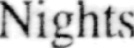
Nights
